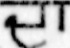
ਦਾ
